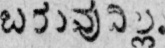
ಬರುವುದಿಲ್ಲ.
